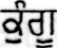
ਕੁੰਗ
